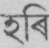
হৰি
